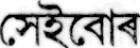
সেইবোৰ
